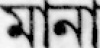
মানা
